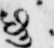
છું.
